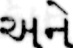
અને
